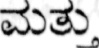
ಮತ್ತು
